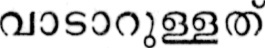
വാടാറുള്ളത്
